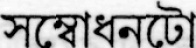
সম্বোধনটো
